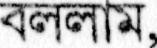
বললাম,
